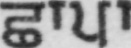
ਛਾਪਾ
